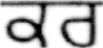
ਕਰ
